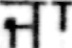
ਜਾ
